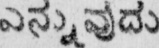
ಎನ್ನುವುದು
